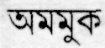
অমমুক
